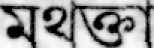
মথক্তা
